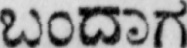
ಬಂದಾಗ
